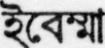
ইবেম্মা
